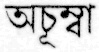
অচূম্বা
